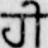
ਹੀ
